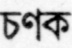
চণক
